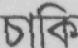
চাকি
